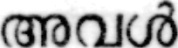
അവള്‍
